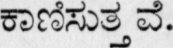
ಕಾಣಿಸುತ್ತವೆ.
